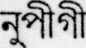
নুপীগী
